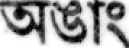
অঙাং
